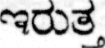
ಇರುತ್ತ
